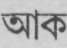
আক
